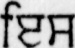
ਇਸ
